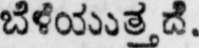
ಬೆಳೆಯುತ್ತದೆ.
